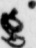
હું
